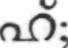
ഹ്;
